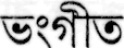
ভংগীত
